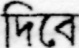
দিবে
